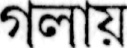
গলায়
